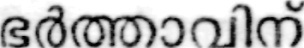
ഭര്‍ത്താവിന്
